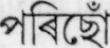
পৰিছোঁ
